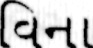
વિના
